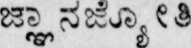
ಜ್ಞಾನಜ್ಯೋತಿ
